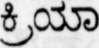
ಕ್ರಿಯಾ
